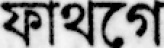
ফথগে
